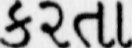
કરતા
